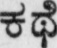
ಕಥೆ
